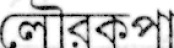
লৌরকপা
